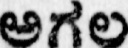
ಅಗಲ
